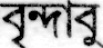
বৃন্দাবু
